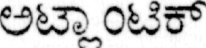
ಅಟ್ಲಾಂಟಿಕ್
